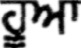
ਹੂਆ
